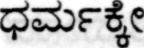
ಧರ್ಮಕ್ಕೇ
